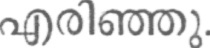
എരിഞ്ഞു.
